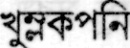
খুম্লকপনি
